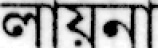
লায়না
